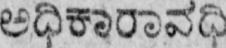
ಅಧಿಕಾರಾವಧಿ
